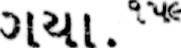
ગયા.૧૫૯
